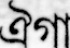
ঐগা
